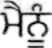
ਮੈਨੂੰ
